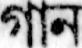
গান
